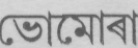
ভোমোৰা
